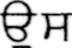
ਉਸ
